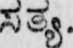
ಸತ್ಯ.
